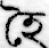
হৈ
